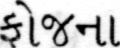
ફોજના
